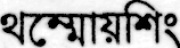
থম্মোয়শিং
